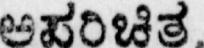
ಅಪರಿಚಿತ.
